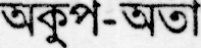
অকুপ-অতা
